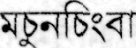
মচুনচিংবা
